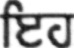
ਇਹ
